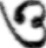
ও
